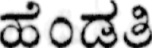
ಹೆಂಡತಿ
